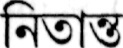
নিতান্ত
